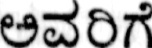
ಅವರಿಗೆ
